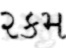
રકમ
